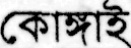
কোঙ্গাই
